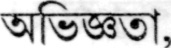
অভিজ্ঞতা,
